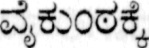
ವೈಕುಂಠಕ್ಕೆ
